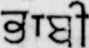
ਭਾਬੀ
